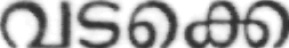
വടക്കെ
